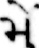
મેં
